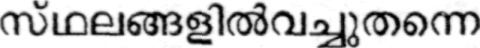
സ്ഥലങ്ങളില്‍വച്ചുതന്നെ
